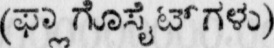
(ಫ್ಲಾಗೊಸೈಟ್‌ಗಳು)
